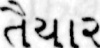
તૈયાર
